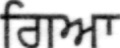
ਗਿਆ
